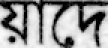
য়াদে
